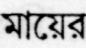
মায়ের
